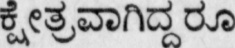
ಕ್ಷೇತ್ರವಾಗಿದ್ದರೂ
